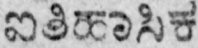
ಐತಿಹಾಸಿಕ
